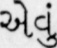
એવું
